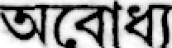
অবোধ্য
